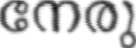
നേരു
